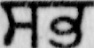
ਸਭ
